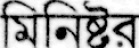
মিনিষ্টর
